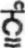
ਨੂੰ
